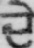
ਦੇ
